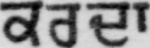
ਕਰਦਾ
